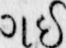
ગઈ
